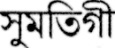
সুমতিগী
